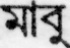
মাবু
